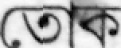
তোক
